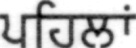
ਪਹਿਲਾਂ
